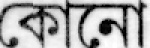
কোনো
